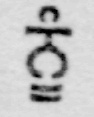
ਨੂੰ
